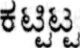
ಕಟ್ಟಿಟ್ಟ
